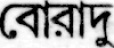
বোরাদু
